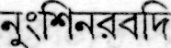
নুংশিনরবদি
